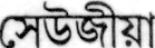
সেউজীয়া
